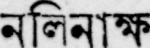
নলিনাক্ষ
